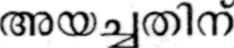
അയച്ചതിന്
